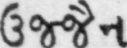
ઉજ્જૈન
